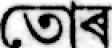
তোৰ
